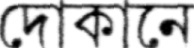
দোকানে
